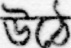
উঠে
